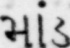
માંડ
